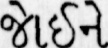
જોઈને
